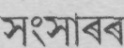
সংসাৰৰ
